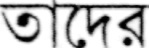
তাদের
